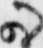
જે
